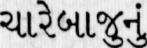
ચારેબાજુનું
